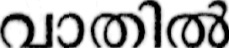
വാതില്‍
